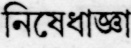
নিষেধাজ্ঞা
